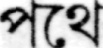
পথে
